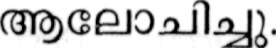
ആലോചിച്ചു.
